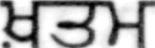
ਖ਼ਤਮ
